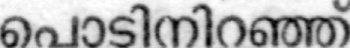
പൊടിനിറഞ്ഞ്
